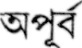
অপূর্ব
